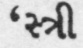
'સ્ત્રી
